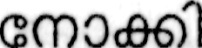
നോക്കി
